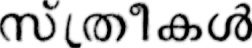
സ്ത്രീകള്‍
